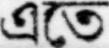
এতে
